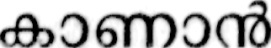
കാണാന്‍
